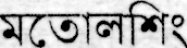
মতোলশিং
